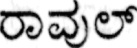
ರಾವುಲ್
